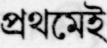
প্রথমেই
